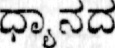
ಧ್ಯಾನದ
